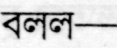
বলল–
